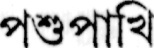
পশুপাখি
